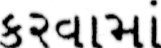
કરવામાં
